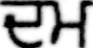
ਦਮ
